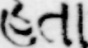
હતા
